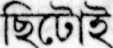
ছিটোই
